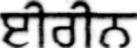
ਈਰੀਨ
